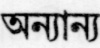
অন্যান্য
